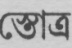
স্তোত্ৰ
